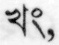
খং,
